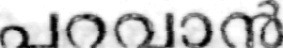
പറവാന്‍
